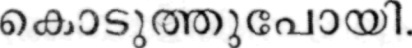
കൊടുത്തുപോയി.
